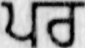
ਪਰ
